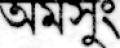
অমসুং
